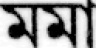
মমা
